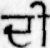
ਦੀ
